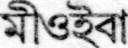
মীওইবা
